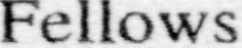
Fellows
